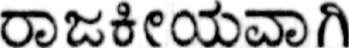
ರಾಜಕೀಯವಾಗಿ
